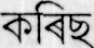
কৰিছ
